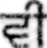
ਵੀ
